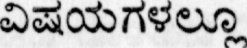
ವಿಷಯಗಳಲ್ಲೂ
